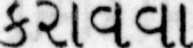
કરાવવા
